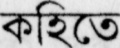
কহিতে
